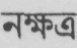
নক্ষত্র
